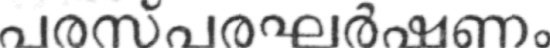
പരസ്പരഘര്‍ഷണം
